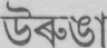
উৰুঙা
